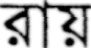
রায়
